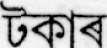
টকাৰ
